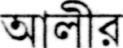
আলীর
